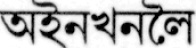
অইনখনলৈ
